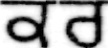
ਕਰ
